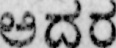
ಅದರ
